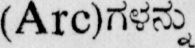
(Arc)ಗಳನ್ನು
